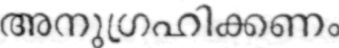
അനുഗ്രഹിക്കണം
